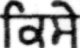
ਕਿਸੇ
